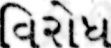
વિરોધ
